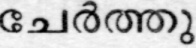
ചേര്‍ത്തു
